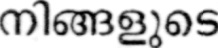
നിങ്ങളുടെ
